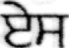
ਏਸ
